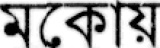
মকোয়
